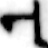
ન
